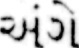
અંગે
